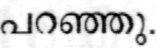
പറഞ്ഞു.
